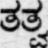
ತತ್ವ
